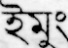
ইমুং
